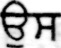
ਉਸ
